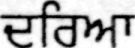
ਦਰਿਆ
